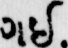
ગઈ.
